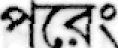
পরেং
